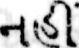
નહીં
